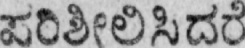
ಪರಿಶೀಲಿಸಿದರೆ
